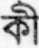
কী
